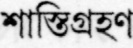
শাস্তিগ্রহণ
